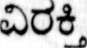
ವಿರಕ್ತಿ
